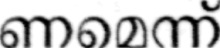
ണമെന്ന്
